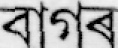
বাগৰ
